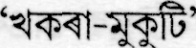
'খকৰা-মুকুটি'
